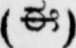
(ಈ)
